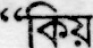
"কিয়
